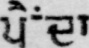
ਪੈਂਦਾ
